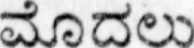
ಮೊದಲು
